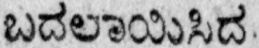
ಬದಲಾಯಿಸಿದ
